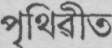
পৃথিৱীত
